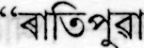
"ৰাতিপুৱা
